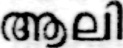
ആലി
